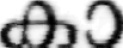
കാ
